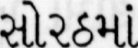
સોરઠમાં
